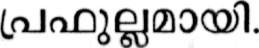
പ്രഫുല്ലമായി.
